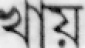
খায়
